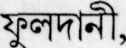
ফুলদানী,
